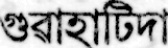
গুৱাহাটিদা
